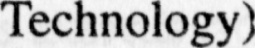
Technology)
